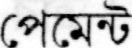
পেমেন্ট
